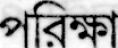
পরিক্ষা
